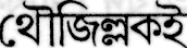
থৌজিল্লকই
